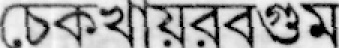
চেকখায়রবগুম
